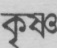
কৃষ্ণ
